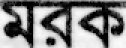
মরক
